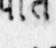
પોતે
